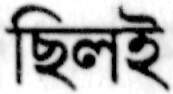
ছিলই
